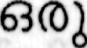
ഒരു
